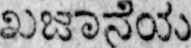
ಖಜಾನೆಯ
